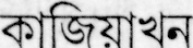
কাজিয়াখন
